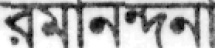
রমানন্দনা
